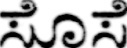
ಸೊಸೆ
